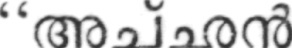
"അച്ഛന്‍
